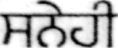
ਸਨੇਹੀ
